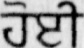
ਹੋਈ
